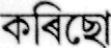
কৰিছো
